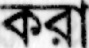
করা
